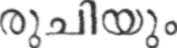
രുചിയും
